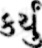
કર્યું
